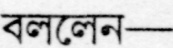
বললেন–
